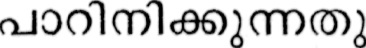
പാറിനിക്കുന്നതു
